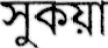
সুকয়া
